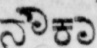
ನೌಕಾ
